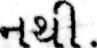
નથી.
